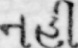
નહીં
